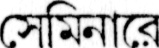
সেমিনারে
